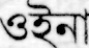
ওইনা
